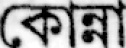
কোন্না
